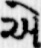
એ
